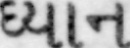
ધ્યાન
